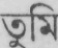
তুমি
